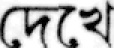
দেখে
